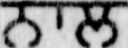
ਨਾਲ
